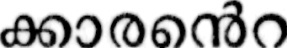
ക്കാരന്റെ
